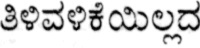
ತಿಳಿವಳಿಕೆಯಿಲ್ಲದ
